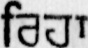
ਰਿਹਾ
